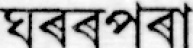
ঘৰৰপৰা
